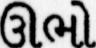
ઊભો
